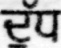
ਦੁੱਧ
